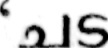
‘ചട
